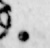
છે.
